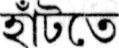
হাঁটতে
